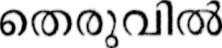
തെരുവില്‍
